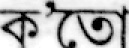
ক'তো
